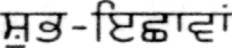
ਸ਼ੁਭ-ਇਛਾਵਾਂ
